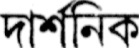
দার্শনিক
